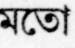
মতো
